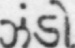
ઝંડો
